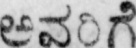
ಅವರಿಗೆ
